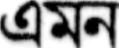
এমন
